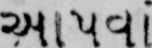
આપવાં
